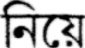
নিয়ে
